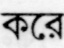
করে
